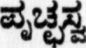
ಪೃಚ್ಛಸ್ವ
